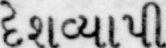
દેશવ્યાપી
